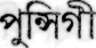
পুন্সিগী
